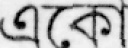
একো
